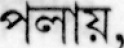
পলায়,
